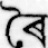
ৰৈ
